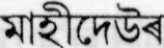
মাহীদেউৰ
